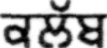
ਕਲੱਬ
